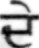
ਦੇ
